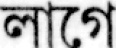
লাগে
